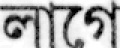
লাগে
